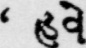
'હવે
